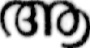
ആ
